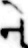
ને
